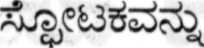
ಸ್ಫೋಟಕವನ್ನು
